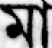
মা
